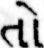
તો
